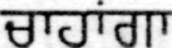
ਚਾਹਾਂਗਾ
